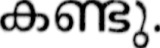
കണ്ടു.
